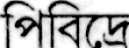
পিবিদ্রে
